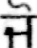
ਜੋ
